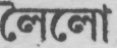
লৈলো
